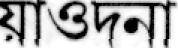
য়াওদনা
